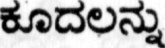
ಕೂದಲನ್ನು
